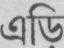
এড়ি
